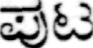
ಪುಟ
